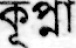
কূপ্না
